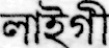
লাইগী
